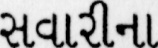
સવારીના
